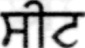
ਸੀਟ
